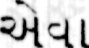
એવા
